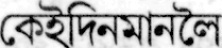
কেইদিনমানলৈ
